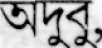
অদুবু,
